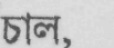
চাল,
